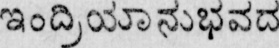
ಇಂದ್ರಿಯಾನುಭವದ
